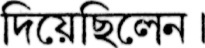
দিয়েছিলেন।
